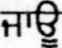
ਜਾਊ
